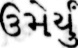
ઉમેર્યું
